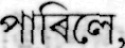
পাৰিলে,
